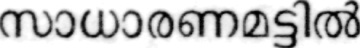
സാധാരണമട്ടില്‍
